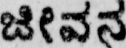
ಜೀವನ
